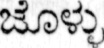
ಜೊಳ್ಳು
